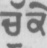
ਚੁੱਕੇ
